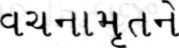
વચનામૃતને
